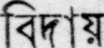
বিদায়
